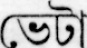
ভেটা
